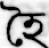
হৈ
